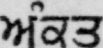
ਅੰਕਤ
